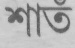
শাতঁ
